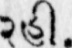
રહી.
